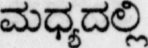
ಮಧ್ಯದಲ್ಲಿ
